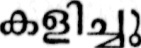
കളിച്ചു
